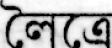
লৈত্রে
